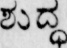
ಶುದ್ಧ
